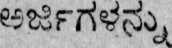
ಅರ್ಜಿಗಳನ್ನು
